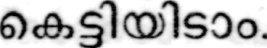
കെട്ടിയിടാം.
